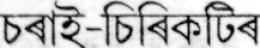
চৰাই-চিৰিকটিৰ
